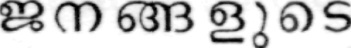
ജനങ്ങളുടെ
